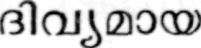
ദിവ്യമായ
